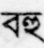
বহু
